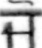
ਜੋ
